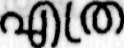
എത്ര
